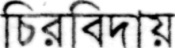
চিরবিদায়
